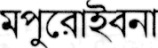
মপুরোইবনা
